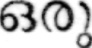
ഒരു
